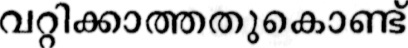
വറ്റിക്കാത്തതുകൊണ്ട്
